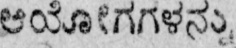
ಆಯೋಗಗಳನ್ನು
